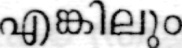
എങ്കിലും
